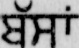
ਬੱਸਾਂ
